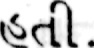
હતી.
